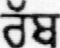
ਰੱਬ
